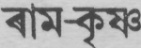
ৰাম-কৃষ্ণ
